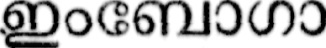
ഇംബോഗാ
